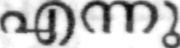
എന്നു
